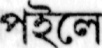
পইলে
